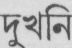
দুখনি
